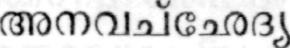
അനവച്ഛേദ്യ
